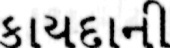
કાયદાની
